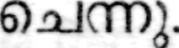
ചെന്നു.
